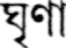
ঘৃণা
